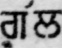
ਗੱਲ
